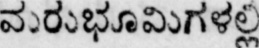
ಮರುಭೂಮಿಗಳಲ್ಲಿ
